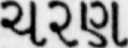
ચરણ
